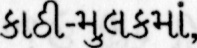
કાઠી-મુલકમાં,
